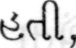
હતી,
